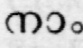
നാം
